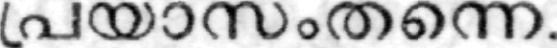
പ്രയാസംതന്നെ.
